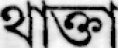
থাক্তা
